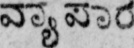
ವ್ಯಾಪಾರ
